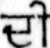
ਦੀ
